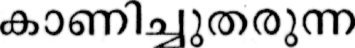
കാണിച്ചുതരുന്ന
